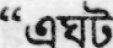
"এঘট
